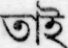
তাই
